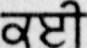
ਕਈ
